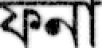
ফনা
